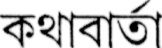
কথাবার্তা
